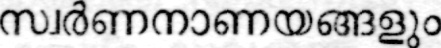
സ്വര്‍ണനാണയങ്ങളും
